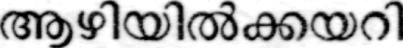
ആഴിയില്‍ക്കയറി
